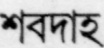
শবদাহ
